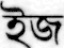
ইজ
